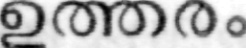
ഉത്തരം
